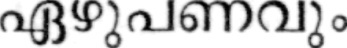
ഏഴുപണവും
